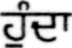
ਹੁੰਦਾ
